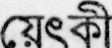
য়েৎকী
